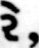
રે,
